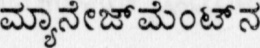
ಮ್ಯಾನೇಜ್‌ಮೆಂಟ್ ನ
